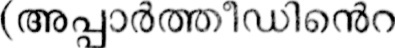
(അപ്പാര്‍ത്തീഡിന്റെ
